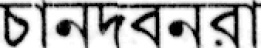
চানদবনরা
